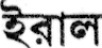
ইরাল
